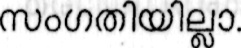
സംഗതിയില്ലാ.
